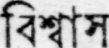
বিশ্বাস
